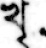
খৃ.
